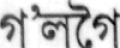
গ'লগৈ
